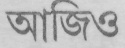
আজিও
